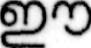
ഈ
